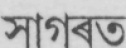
সাগৰত
